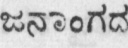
ಜನಾಂಗದ
